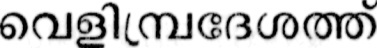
വെളിമ്പ്രദേശത്ത്
